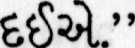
દઈએ."
